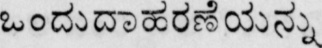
ಒಂದುದಾರಣೆಯನ್ನು
